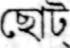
ছোট্‌
